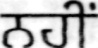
ਨਹੀਂ
